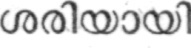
ശരിയായി
